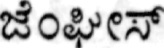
ಜೆಂಘೀಸ್
